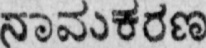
ನಾಮಕರಣ
